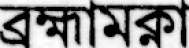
ব্রহ্মামক্না
